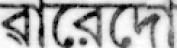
ৱারেদো
